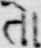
તો
